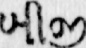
બીજી
